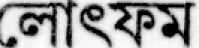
লোৎফম
